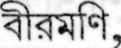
বীরমণি,
